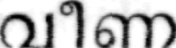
വീണ
